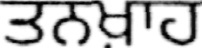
ਤਨਖ਼ਾਹ
